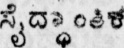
ಸೈದ್ಧಾ೦ತಿಕ
